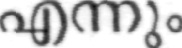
എന്നും
